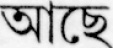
আছে
